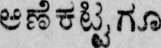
ಅಣೆಕಟ್ಟಿಗೂ
